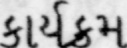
કાર્યક્રમ
